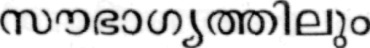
സൌഭാഗ്യത്തിലും
